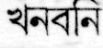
খনবনি
